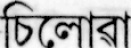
চিলোৱা
